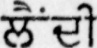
ਲੈਂਦੀ
